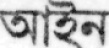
আইন
